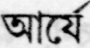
আর্যে
